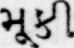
મૂકી
